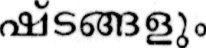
ഷ്ടങ്ങളും
